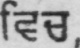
ਵਿਚ,
